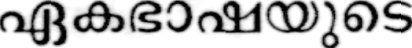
ഏകഭാഷയുടെ
